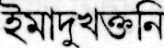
ইমাদুখক্তনি
